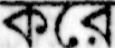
করে
